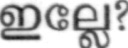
ഇല്ലേ?
